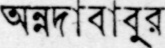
অন্নদাবাবুর
